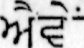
ਐਵੇਂ
